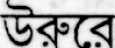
উরুরে
